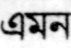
এমন
